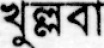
খুল্লবা
